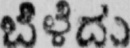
ಬೆಳೆದು
